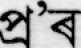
প্র'ৰ
